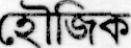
হৌজিক
